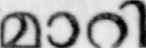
മാറി
